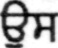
ਉਸ
